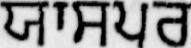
ਯਾਸਪਰ
